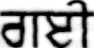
ਗਈ
